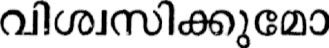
വിശ്വസിക്കുമോ
